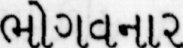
ભોગવનાર
